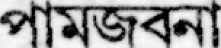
পামজবনা
